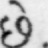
છે.
